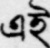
এই
